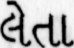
લેતા
